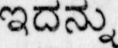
ಇದನ್ನು
